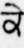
ਕੇ
